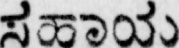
ಸಹಾಯ
